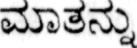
ಮಾತನ್ನು
